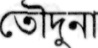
তৌদুনা
